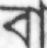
বা
